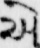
એ
